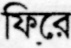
ফিরে
